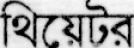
থিয়েটর
